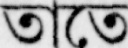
তাতে
